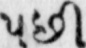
પછી
